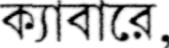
ক্যাবারে,
